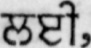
ਲਈ,
